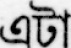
এটা
